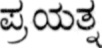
ಪ್ರಯತ್ನ
